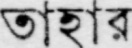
তাহার
